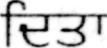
ਦਿਤਾ
